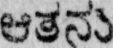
ಆತನು
